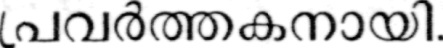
പ്രവര്‍ത്തകനായി.
